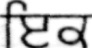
ਇਕ
